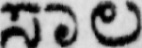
ಸಾಲ
